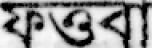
ফত্তবা
